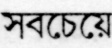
সবচেয়ে
